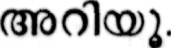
അറിയൂ.
